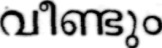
വീണ്ടും
